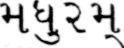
મધુરમ્
